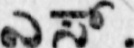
ಎಸ್.
